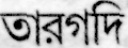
তারগদি
